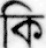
কি
